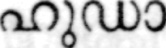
ഹുഡാ
